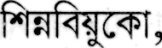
শিন্নবিয়ুকো,
